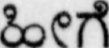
ಹೀಗೆ
